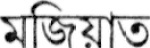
মজিয়াত
